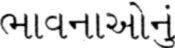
ભાવનાઓનું
